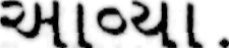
આવ્યા.
